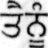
ਤੈਨੂੰ
